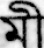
মী
